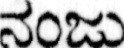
ನಂಜು
